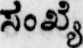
ಸಂಖ್ಯೆ
